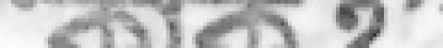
'কাক? '
